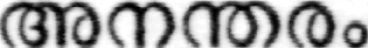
അനന്തരം
